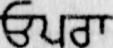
ਓਪਰਾ
